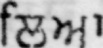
ਲਿਆ
